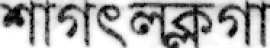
শাগৎলক্লগা
